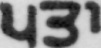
ਪਤਾ
